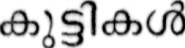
കുട്ടികള്‍
